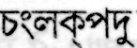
চংলকপদু
